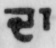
ਦਾ
